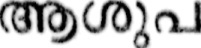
ആശുപ
